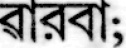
ৱারবা;
